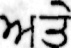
ਅਤੇ
